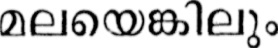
മലയെങ്കിലും
